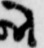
જો
